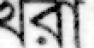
খরা
